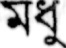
মধু
